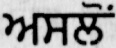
ਅਸਲੋਂ
